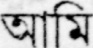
আমি
